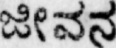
ಜೀವನ
